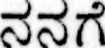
ನನಗೆ
